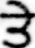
ਤੇ
